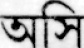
অসি
